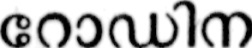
റോഡിന
